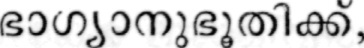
ഭാഗ്യാനുഭൂതിക്ക്,
